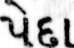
પેદા
